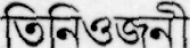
তিনিওজনী
